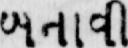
બનાવી
